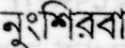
নুংশিরবা
